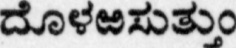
ದೊಳಱಸುತ್ತುಂ
